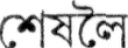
শেষলৈ
